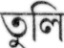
তুলি
